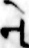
ને
